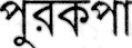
পুরকপা
